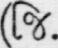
(જિ.
